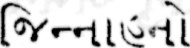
જિન્નાહનો
